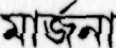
মার্জনা
